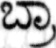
ಬ್ರಾ
